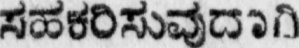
ಸಹಕರಿಸುವುದಾಗಿ
